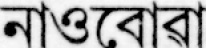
নাওবোৱা
